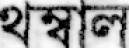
থম্বাল
